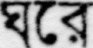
ঘরে
